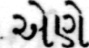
એણે
